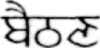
ਬੈਠਣ
